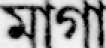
মাগা
